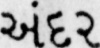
અંદર
